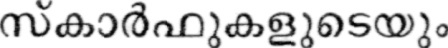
സ്കാര്‍ഫുകളുടെയും
